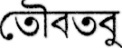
তৌবতবু
